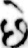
છે
